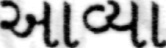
આવ્યા
